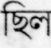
ছিল
